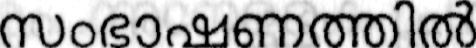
സംഭാഷണത്തില്‍
